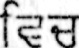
ਵਿਚ
